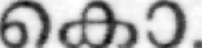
കൊ.
